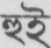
হুই
